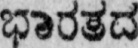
ಭಾರತದ
